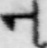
ન
